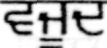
ਵਜੂਦ
